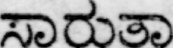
ಸಾರುತಾ
